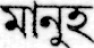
মানুহ
